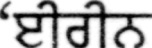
'ਈਰੀਨ
